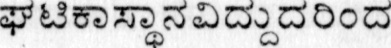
ಘಟಿಕಾಸ್ಥಾನವಿದ್ದುದರಿಂದ
